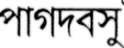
পাগদবসু
